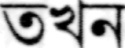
তখন
